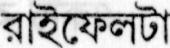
রাইফেলটা
